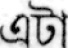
এটা
